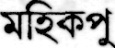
মহিকপু
